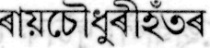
ৰায়চৌধুৰীহঁতৰ
